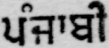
ਪੰਜਾਬੀ
